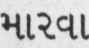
મારવા
